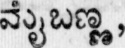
ಮೈಬಣ್ಣ,
